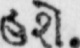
હશે.
